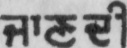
ਜਾਣਦੀ
